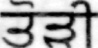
ਤੋੜੀ
